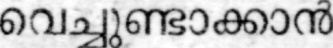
വെച്ചുണ്ടാക്കാന്‍
